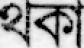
থকা
